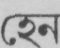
হেন
